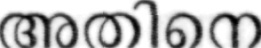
അതിനെ
